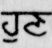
ਹੁਣ
